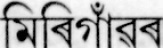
মিৰিগাঁৱৰ
